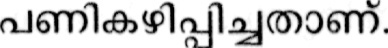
പണികഴിപ്പിച്ചതാണ്.
